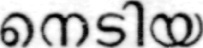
നെടിയ
